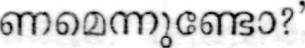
ണമെന്നുണ്ടോ?'
